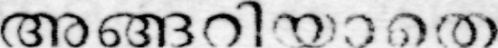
അങ്ങറിയാതെ
